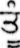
ਤੂੰ
